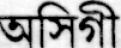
অসিগী
